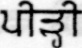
ਪੀੜ੍ਹੀ
